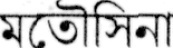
মতৌসিনা
